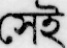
সেই
